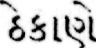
ઠેકાણે
